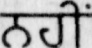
ਨਹੀਂ
